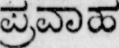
ಪ್ರವಾಹ
